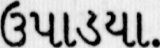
ઉપાડયા.
